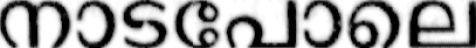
നാടപോലെ
